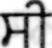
ਸੀ
